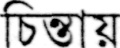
চিন্তায়
